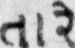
તારે
